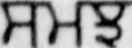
ਸਮਝ
